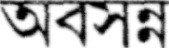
অবসন্ন
